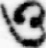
ও
